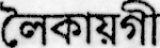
লৈকায়গী
